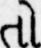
તો
